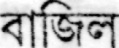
বাজিল
